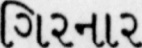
ગિરનાર
